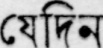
যেদিন
